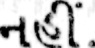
નહીં.
